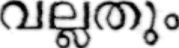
വല്ലതും
